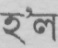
হ'ল
